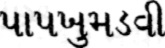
પાપખુમડવી
